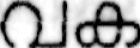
വക
